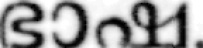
ഭാഷ.
